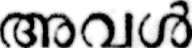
അവള്‍
